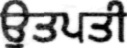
ਉਤਪਤੀ
